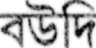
বউদি
